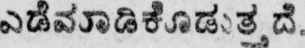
ಎಡೆಮಾಡಿಕೊಡುತ್ತದೆ.
